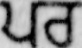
ਪਰ
